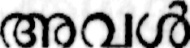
അവള്‍
